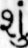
શું
